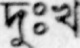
দুঃখ
